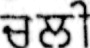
ਚਲੀ
